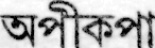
অপীকপা
